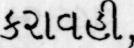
કરાવહી,
